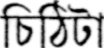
চিঠিটা
